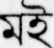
মই
